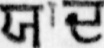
ਯਾਦ
